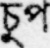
চুপ
